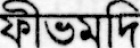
ফীভমদি
